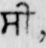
ਸੀ,
